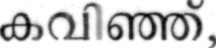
കവിഞ്ഞ്,
